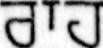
ਰਾਹ
